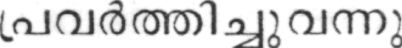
പ്രവര്‍ത്തിച്ചുവന്നു
